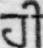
ਹੀ
